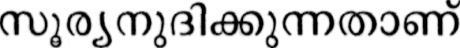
സൂര്യനുദിക്കുന്നതാണ്
